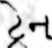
ટ્રેન
